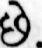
છે.
